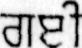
ਗਈ
